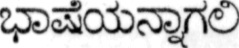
ಭಾಷೆಯನ್ನಾಗಲಿ
